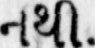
નથી.
